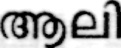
ആലി
